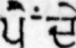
ਪੈਂਦੇ
